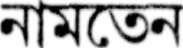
নামতেন
